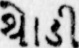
થોડી
